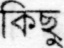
কিছু
